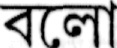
বলো
